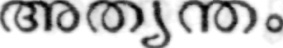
അത്യന്തം
